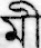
মী
